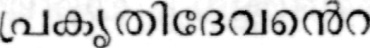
പ്രകൃതിദേവന്റെ
